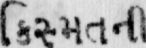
કિસ્મતની
